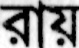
রায়
